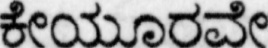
ಕೇಯೂರವೇ
